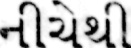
નીચેથી
